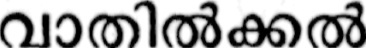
വാതില്‍ക്കല്‍
